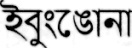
ইবুংঙোনা
